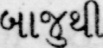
બાજુથી
